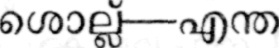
ശൊല്ല്-എന്ത
